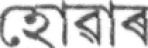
হোৱাৰ
